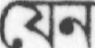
যেন
